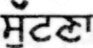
ਸੁੱਟਣਾ
